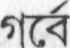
গর্বে
